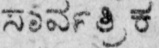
ಸಾರ್ವತ್ರಿಕ
